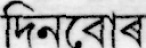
দিনবোৰ
